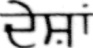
ਦੇਸ਼ਾਂ
